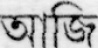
আজি
